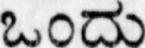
ಒಂದು
